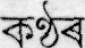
কণ্ঠৰ
